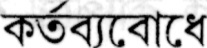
কর্তব্যবোধে
